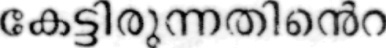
കേട്ടിരുന്നതിന്റെ
